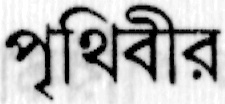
পৃথিবীর
